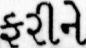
ફરીને
